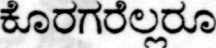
ಕೊರಗರೆಲ್ಲರೂ
